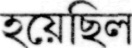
হয়েছিল
